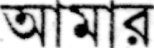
আমার
